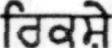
ਰਿਕਸ਼ੇ
